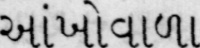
આંખોવાળા
